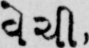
વેચી,
